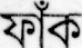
ফাঁক
